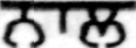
ਨਾਲ
